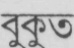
বুকুত
